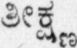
ತೀಕ್ಷ್ಣ
